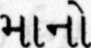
માનો
